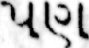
પણ
